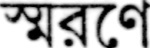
স্মরণে
